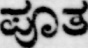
ಪೂತ
